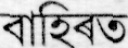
বাহিৰত
